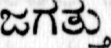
ಜಗತ್ತು
